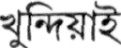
খুন্দিয়াই
